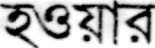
হওয়ার
